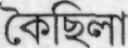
কৈছিলা
